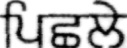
ਪਿਛਲੇ
